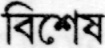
বিশেষ
